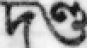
দণ্ড
